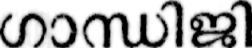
ഗാന്ധിജി
